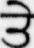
ਤੇ
